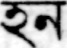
হন
